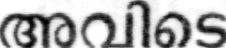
അവിടെ
